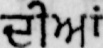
ਦੀਆਂ
